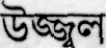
উজ্জ্বল
